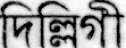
দিল্লীগী
